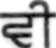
ਵੀ
